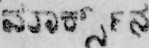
ಮಾರ್ಕ್ಸ್ನ
